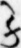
કે
